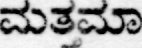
ಮತ್ತಮಾ
